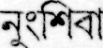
নুংশিবা
